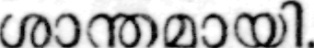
ശാന്തമായി.
